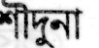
শৌদুনা
